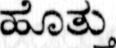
ಹೊತ್ತು
